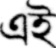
এই
